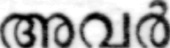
അവര്‍
